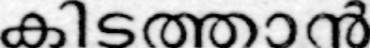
കിടത്താന്‍
